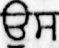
ਉਸ
